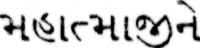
મહાત્માજીને
